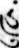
હું
